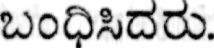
ಬಂಧಿಸಿದರು.
